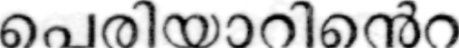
പെരിയാറിന്റെ
